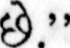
છે."
